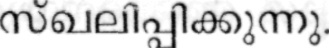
സ്ഖലിപ്പിക്കുന്നു.
